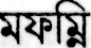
মফম্নি
